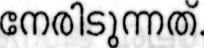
നേരിടുന്നത്.
